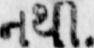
નથી.
